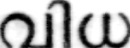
വിധ
